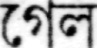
গেল
